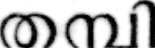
തമ്പി
